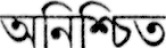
অনিশ্চিত
